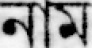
নাম
